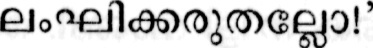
ലംഘിക്കരുതല്ലോ!’
